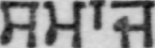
ਸਮਾਜ
